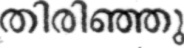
തിരിഞ്ഞു
